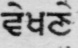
ਵੇਖਣੇ
